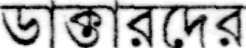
ডাক্তারদের
